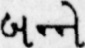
બન્ને
